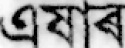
এষাৰ
